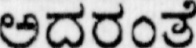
ಅದರಂತೆ
